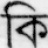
কি
